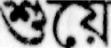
শুয়ে
